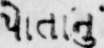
પોતાનું
